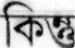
কিন্তু
